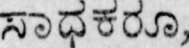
ಸಾಧಕರೂ,
